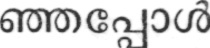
ഞ്ഞപ്പോള്‍
